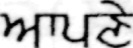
ਆਪਣੇ
